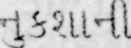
નુકશાની
